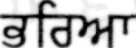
ਭਰਿਆ
